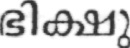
ഭിക്ഷു
